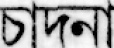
চাদনা
